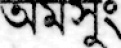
অমসুং
